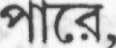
পারে,
